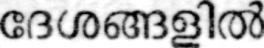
ദേശങ്ങളില്‍
